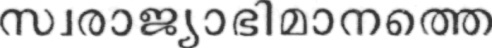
സ്വരാജ്യാഭിമാനത്തെ
